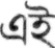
এই
